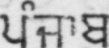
ਪੰਜਾਬ
